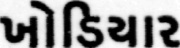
ખોડીયાર
